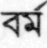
বর্ম
